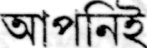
আপনিই
